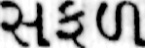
સફળ
